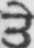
ਤੇ
